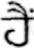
ਹੈਂ
